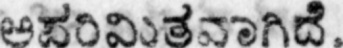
ಅಪರಿಮಿತವಾಗಿದೆ.
